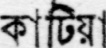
কাটিয়া
